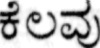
ಕೆಲವು
